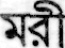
মরী
